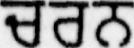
ਚਰਨ
